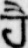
ਹੈ
